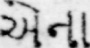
એના
